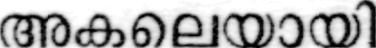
അകലെയായി
